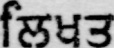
ਲਿਖਤ
